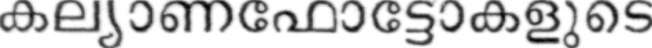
കല്യാണഫോട്ടോകളുടെ
